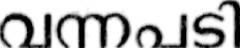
വന്നപടി
